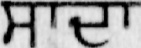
ਸਾਦਾ
